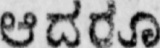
ಆದರೂ
